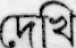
দেখি
